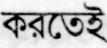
করতেই
